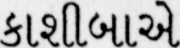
કાશીબાએ
